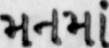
મનમાં
